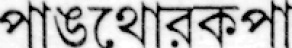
পাঙথোরকপা
